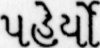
પહેર્યો
